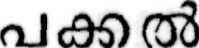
പക്കല്‍
